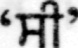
'ਸੀ'
